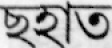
ছহাত
